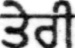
ਤੇਰੀ
